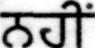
ਨਹੀਂ
